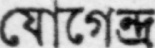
যোগেন্দ্র
